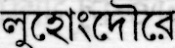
লুহোংদৌরে
